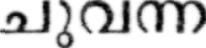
ചുവന്ന
